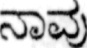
ನಾವು
